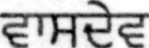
ਵਾਸਦੇਵ
